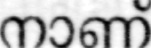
നാണ്
